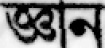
জ্ঞান
